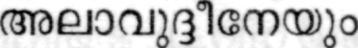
അലാവുദ്ദീനേയും
